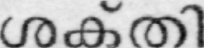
ശക്തി
